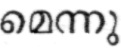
മെന്നു
